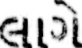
લાગે
